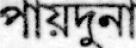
পায়দুনা
